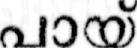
പായ്
